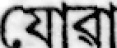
যোৱা
